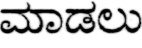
ಮಾಡಲು
